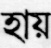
হায়
